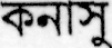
কনাসু
